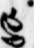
હું
